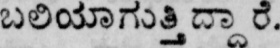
ಬಲಿಯಾಗುತ್ತಿದ್ದಾರೆ.
